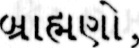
બ્રાહ્મણો,
